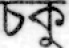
চকু
